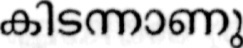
കിടന്നാണു
